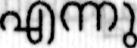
എന്നു
